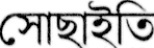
সোছাইতি
